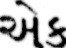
એક
